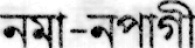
নমা-নপাগী
